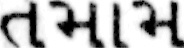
તમામ
